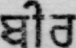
ਬੀਰ
